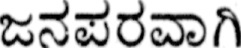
ಜನಪರವಾಗಿ
